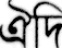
ঐদি
